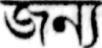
জন্য
